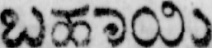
ಬಹಾಯಿ
